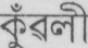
কুঁৱলী
